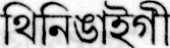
থিনিঙাইগী
